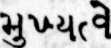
મુખ્યત્વે
